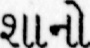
શાનો
